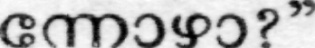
ന്നോഴാ?''
